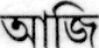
আজি
